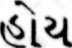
હોય
